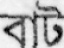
বাট
